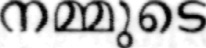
നമ്മുടെ
